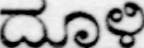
ದೂಳಿ
